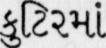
કુટિરમાં
